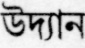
উদ্যান
